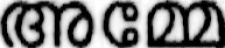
അമ്മേ
